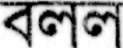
বলল
